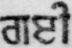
ਗਈ
